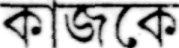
কাজকে
